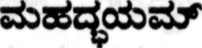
ಮಹದ್ಧಯಮ್
